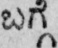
ಬಗ್ಗೆ
